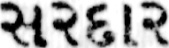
સરદાર
